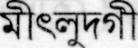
মীৎলুদগী
